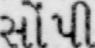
સોંપી
